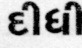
દીધી
